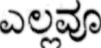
ಎಲ್ಲವೂ
